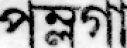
পম্লগা
